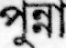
পুন্না
